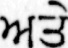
ਅਤੇ
